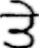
ਤੇ
